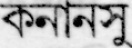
কনানসু
